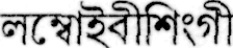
লম্বোইবীশিংগী
